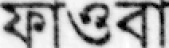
ফাওবা
